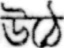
উঠে
